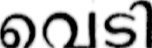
വെടി
